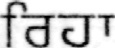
ਰਿਹਾ
